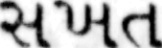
સખત
